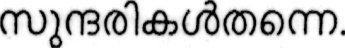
സുന്ദരികള്‍തന്നെ.
